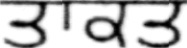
ਤਾਕਤ
